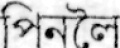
পিনলৈ
